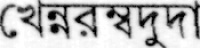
খেন্নরম্বদুদা
